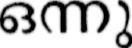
ഒന്നു
